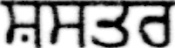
ਸ਼ਸਤਰ
